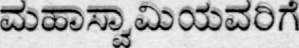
ಮಹಾಸ್ವಾಮಿಯವರಿಗೆ
